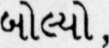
બોલ્યો,
